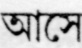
আসে
